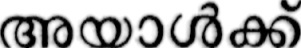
അയാള്‍ക്ക്
